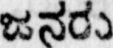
ಜನರು
